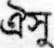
ঐসু
